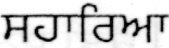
ਸਹਾਰਿਆ
